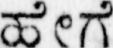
ಹೇಗೆ
